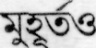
মুহূর্তও
